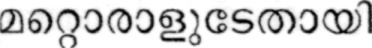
മറ്റൊരാളുടേതായി
